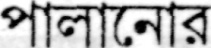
পালানোর
